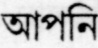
আপনি
